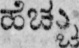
ಹೆಚ್ಚು
